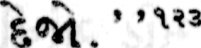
દેજો."૧૨૩
